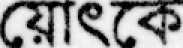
য়োৎকে
